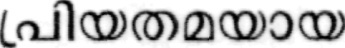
പ്രിയതമയായ
